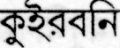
কুইরবনি
